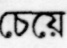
চেয়ে
